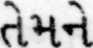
તેમને
